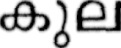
കുല
